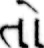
તો
